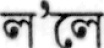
ল'লে
